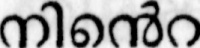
നിന്റെ
